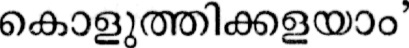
കൊളുത്തിക്കളയാം'
